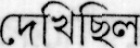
দেখিছিল
